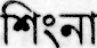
শিংনা
